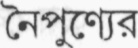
নৈপুণ্যের
